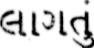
લાગતું
